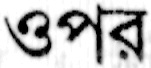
ওপর
